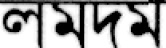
লমদম
